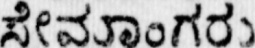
ಸೇಮಾಂಗರು
